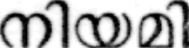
നിയമി
